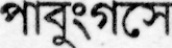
পাবুংগসে
